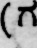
(ಗ
